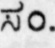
ಸಂ.
